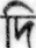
দি
